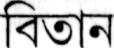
বিতান
